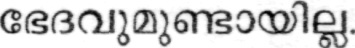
ഭേദവുമുണ്ടായില്ല.
